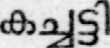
കച്ചട്ടി
